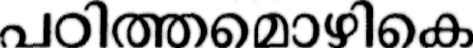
പഠിത്തമൊഴികെ
